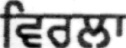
ਵਿਰਲਾ
